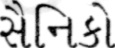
સૈનિકો
